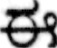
ಈ
